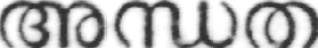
അന്ധത
